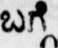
ಬಗ್ಗೆ
